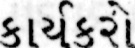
કાર્યકરો
